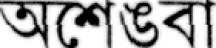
অশেঙবা
